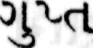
ગુપ્ત
